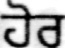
ਹੋਰ
